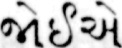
જોઇએ
